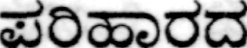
ಪರಿಹಾರದ
